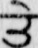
ਤੇ
